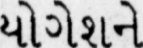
યોગેશને
